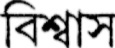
বিশ্বাস
